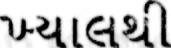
ખ્યાલથી
